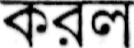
করল
